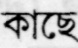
কাছে
